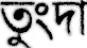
তুংদা
